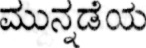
ಮುನ್ನಡೆಯ
